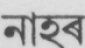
নাহৰ
